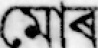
মোৰ
